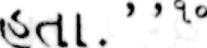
હતા."૧૦
